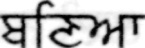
ਬਣਿਆ
